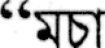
“মচা
